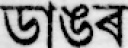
ডাঙৰ
